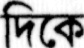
দিকে
